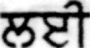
ਲਈ
